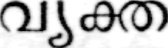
വ്യക്ത
